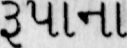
રૂપાના
